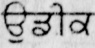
ਉਡੀਕ
